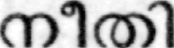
നീതി
